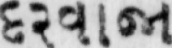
દરવાજા
